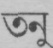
তনু
